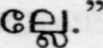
ല്ലേ."
